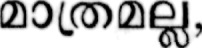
മാത്രമല്ല,
